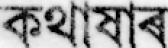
কথাষাৰ
